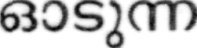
ഓടുന്ന
